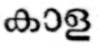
കാള
